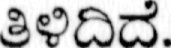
ತಿಳಿದಿದೆ.
